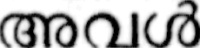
അവള്‍
